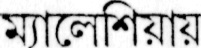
ম্যালেশিয়ায়
